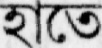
হাতে
